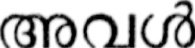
അവള്‍
